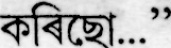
কৰিছো..."
